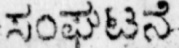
ಸಂಘಟನೆ
